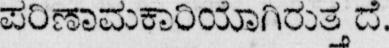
ಪರಿಣಾಮಕಾರಿಯಾಗಿರುತ್ತದೆ.
